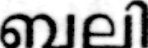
ബലി
